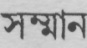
সম্মান
